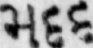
મદદ
